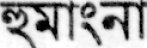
হুমাংনা
